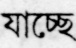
যাচ্ছে
